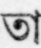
তা
